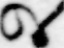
જ
